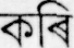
কৰি
